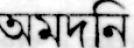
অমদনি
